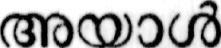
അയാള്‍
